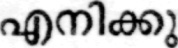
എനിക്കു
